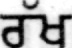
ਰੱਖ
